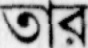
তার
